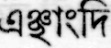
এঞ্ছাংদি
